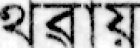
থৱায়
